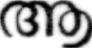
ആ
